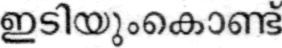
ഇടിയുംകൊണ്ട്
